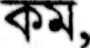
কম,
